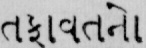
તફાવતનો
